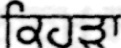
ਕਿਹੜਾ
